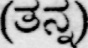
(ತನ್ನ)
